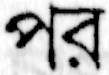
পর
